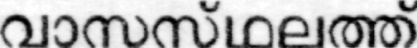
വാസസ്ഥലത്ത്
